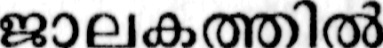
ജാലകത്തില്‍
